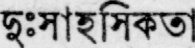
দুঃসাহসিকতা
